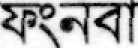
ফংনবা
